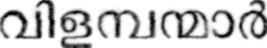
വിളമ്പന്മാര്‍
